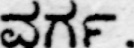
ವರ್ಗ.
